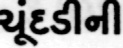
ચૂંદડીની
